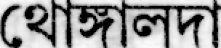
থোঙ্গালদা
